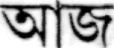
আজ
